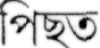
পিছত
